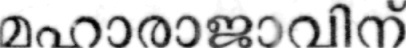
മഹാരാജാവിന്
